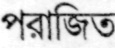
পরাজিত
